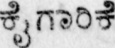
ಕೈಗಾರಿಕೆ
